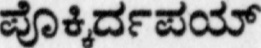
ಪೊಕ್ಕಿರ್ದಪಯ್
